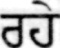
ਰਹੇ
